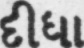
દીધા
